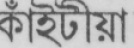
কাঁইটীয়া
